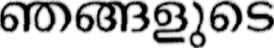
ഞങ്ങളുടെ
